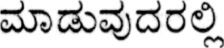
ಮಾಡುವುದರಲ್ಲಿ
